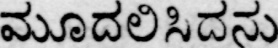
ಮೂದಲಿಸಿದನು
